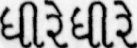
ધીરેધીરે
